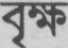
বৃক্ষ
